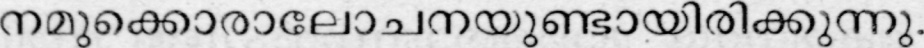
നമുക്കൊരാലോചനയുണ്ടായിരിക്കുന്നു.
